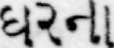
ઘરના
